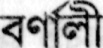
বর্ণালী
